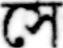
সে
